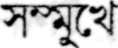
সম্মুখে
